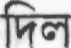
দিল
